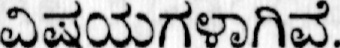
ವಿಷಯಗಳಾಗಿವೆ.
